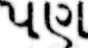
પણ
